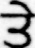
ਤੇ
